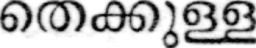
തെക്കുള്ള
